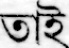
তাই
